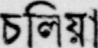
চলিয়া
